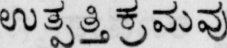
ಉತ್ಪತ್ತಿಕ್ರಮವು
